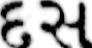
દસ
